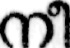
നീ
